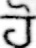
ਹੋ
